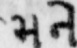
મને
